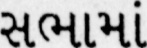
સભામાં
